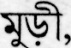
মুডী,
